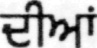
ਦੀਆਂ
